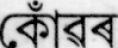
কোঁৱৰ
